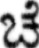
ಚೆ
